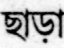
ছাড়া
